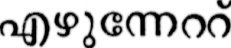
എഴുന്നേററ്
